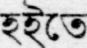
হইতে
